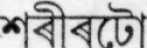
শৰীৰটো
